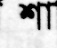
শা
